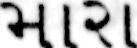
મારા
